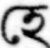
হে
